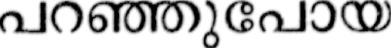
പറഞ്ഞുപോയ
